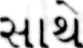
સાથે
